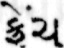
ફ્રેંચ
